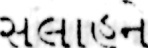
સલાહને
